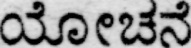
ಯೋಚನೆ
